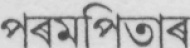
পৰমপিতাৰ
